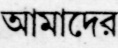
আমাদের
